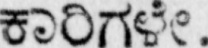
ಕಾರಿಗಳೇ.
